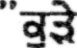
''ਕੁੜੇ
